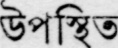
উপস্থিত
